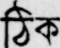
ঠিক
